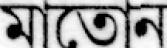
মাতোন
